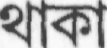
থাকা
